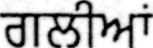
ਗਲੀਆਂ
